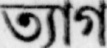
ত্যাগ
